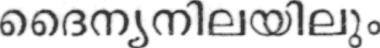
ദൈന്യനിലയിലും
